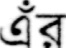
এঁর
